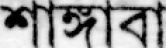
শাঙ্গাবা
